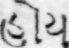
હોય
